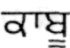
ਕਾਬੂ
